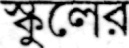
স্কুলের
